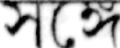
সঙ্গে
